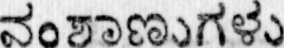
ವಂಶಾಣುಗಳು
